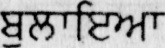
ਬੁਲਾਇਆ
